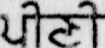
ਪੀਣੀ
